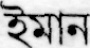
ইমান
